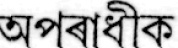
অপৰাধীক
